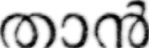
താന്‍
